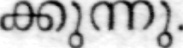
ക്കുന്നു.
